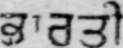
ਭਾਰਤੀ
